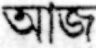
আজ
